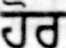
ਹੋਰ
